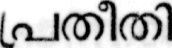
പ്രതീതി
